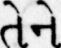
તેને
